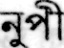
নুপী
